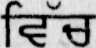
ਵਿੱਚ
